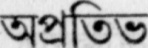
অপ্রতিভ
